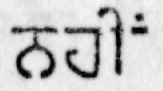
ਨਹੀਂ
